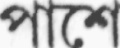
পাশে
